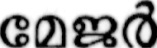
മേജര്‍
